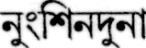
নুংশিনদুনা
